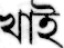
খাই
